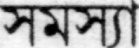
সমস্যা
